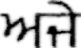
ਅਜੇ
